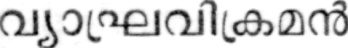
വ്യാഘ്രവിക്രമന്‍
